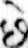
છે
